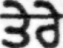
ਤੇਰੇ
